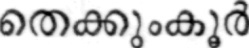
തെക്കുംകൂര്‍
